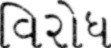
વિરોધ
